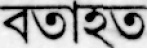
বতাহত
